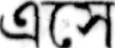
এসে
